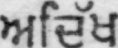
ਅਦਿੱਖ
